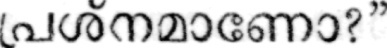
പ്രശ്നമാണോ?"
